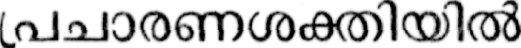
പ്രചാരണശക്തിയില്‍
